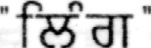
''ਲਿੰਗ''
